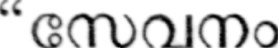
"സേവനം
